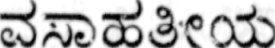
ವಸಾಹತೀಯ
